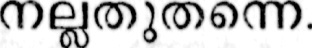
നല്ലതുതന്നെ.
